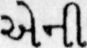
એની
